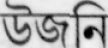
উজনি
